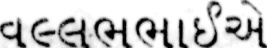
વલ્લભભાઈએ
